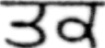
ਤਕ
